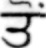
ਤੋਂ
